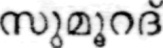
സുമൂറദ്
